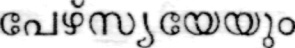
പേഴ്സ്യയേയും
